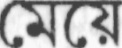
মেয়ে
